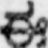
ಈ
